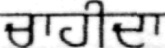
ਚਾਹੀਦਾ
